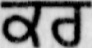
ਕਰ
